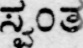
ಸ್ವಂತ
